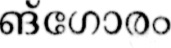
ങ്ഗോരം
